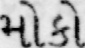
મોકો
